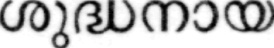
ശുദ്ധനായ
